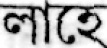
লাহে
